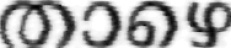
താഴെ
